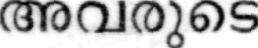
അവരുടെ
